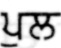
ਪੁਲ
